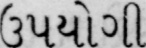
ઉપયોગી
